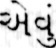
એવું
